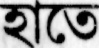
হাতে
